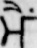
ਮੈਂ
